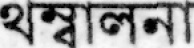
থম্বালনা
